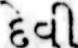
દેવી
